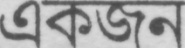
একজন
